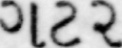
ગટર
